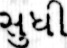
સુધી
